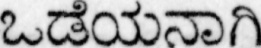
ಒಡೆಯನಾಗಿ
